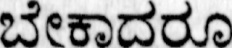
ಬೇಕಾದರೂ
